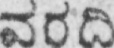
ವರದಿ
